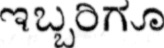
ಇಬ್ಬರಿಗೂ
